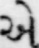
એ
